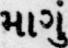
માગું
